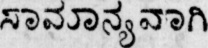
ಸಾಮಾನ್ಯವಾಗಿ
